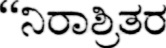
"ನಿರಾಶ್ರಿತರ
